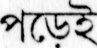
পড়েই
